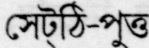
সেট্ঠি-পুত্ত
